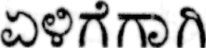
ಏಳಿಗೆಗಾಗಿ
